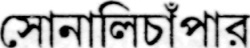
সোনালিচাঁপার
